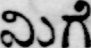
ಮಿಗೆ
